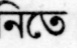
নিতে
